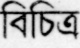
বিচিত্র
